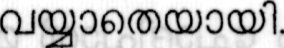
വയ്യാതെയായി.
